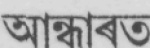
আন্ধাৰত
